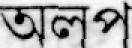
অলপ
